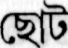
ছোট
